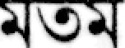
মতম
